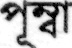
পূম্বা
